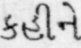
કહીને
